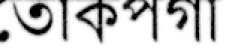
তোকপগা
